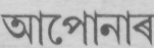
আপোনাৰ
